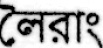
লৈরাং
